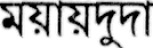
ময়ায়দুদা
